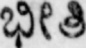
ಭೀತಿ
